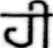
ਹੀ
